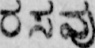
ರಸವು
